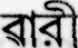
ৱারী
